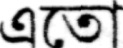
এতো
